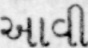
આવી
